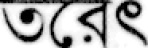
তরেৎ
